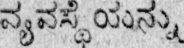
ವ್ಯವಸ್ಥೆಯನ್ನು
